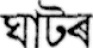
ঘাটৰ
